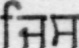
ਜਿਸ
